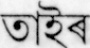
তাইৰ
